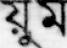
য়ুম
